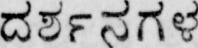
ದರ್ಶನಗಳ
